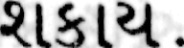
શકાય.
